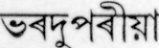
ভৰদুপৰীয়া
